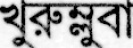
খুরুম্লুবা
